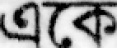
একে
